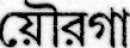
য়ৌরগা
